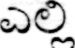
ಎಲ್ಲಿ
